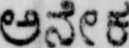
ಅನೇಕ
